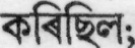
কৰিছিল;
